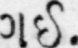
ગઈ.
